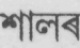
শালৰ
